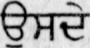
ਉਸਦੇ
